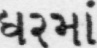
ઘરમાં
